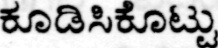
ಕೂಡಿಸಿಕೊಟ್ಟು
